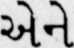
એને
